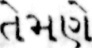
તેમણે
